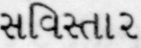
સવિસ્તાર
